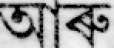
আৰু
